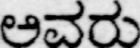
ಅವರು
